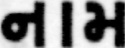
નામ
